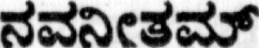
ನವನೀತಮ್
